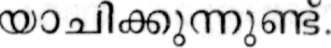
യാചിക്കുന്നുണ്ട്.
